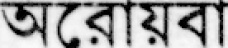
অরোয়বা
